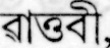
ৱাত্তবী,
